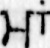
ਮਾਂ
